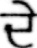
ਦੇ
